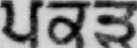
ਪਕੜ
